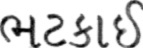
ભટકાઈ
